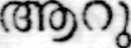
ആറു
